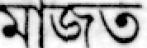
মাজত
